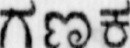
ಗಣಕ
